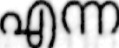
എന്ന
